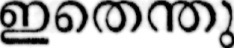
ഇതെന്തു
